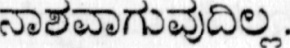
ನಾಶವಾಗುವುದಿಲ್ಲ.
